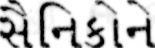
સૈનિકોને
